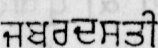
ਜਬਰਦਸਤੀ
